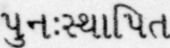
પુનઃસ્થાપિત
